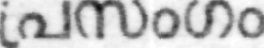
പ്രസംഗം
